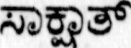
ಸಾಕ್ಷಾತ್
